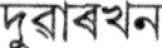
দুৱাৰখন
